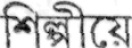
শিল্পীয়ে
